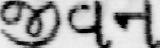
જીવન
